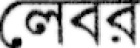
লেবর
